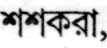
শশকরা,
